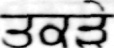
ਤਕੜੇ
